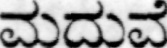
ಮದುವೆ
